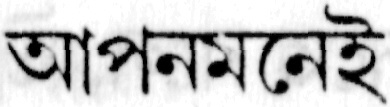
আপনমনেই
